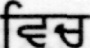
ਵਿਚ
